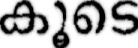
കൂടെ
